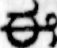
ಈ
